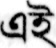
এই
